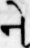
ને
